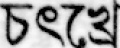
চৎখ্রে
